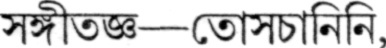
সতীতজ্ঞ-তোসচানিনি,
